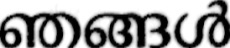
ഞങ്ങള്‍
